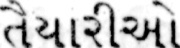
તૈયારીઓ
